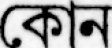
কোন
